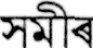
সমীৰ
